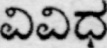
ವಿವಿಧ
